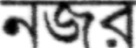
নজর
